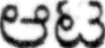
ಆಟ
